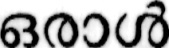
ഒരാള്‍
